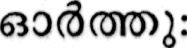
ഓര്‍ത്തു:
